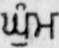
ਘੁੰਮ
